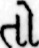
તો
